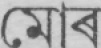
মোৰ
